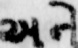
અને
